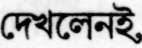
দেখলেনই,
